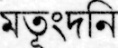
মতূংদনি
